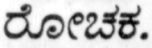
ರೋಚಕ,
